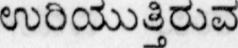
ಉರಿಯುತ್ತಿರುವ
